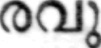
രവു
